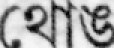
থোঙ
